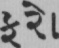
ફરો
